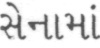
સેનામાં
